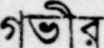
গভীর
